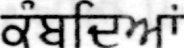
ਕੰਬਦਿਆਂ
